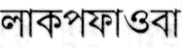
লাকপফাওবা
